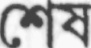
শেষ
